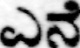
ಎನೆ
